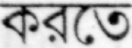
করতে
